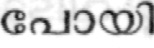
പോയി
